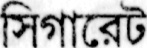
সিগারেট
